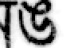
নঙ
